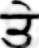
ਤੇ
